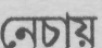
নেচায়
